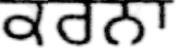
ਕਰਨਾ
